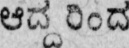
ಆದ್ದರಿಂದ
